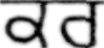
ਕਰ
